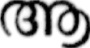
ആ
